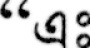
“এঃ
